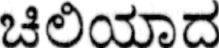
ಚಿಲಿಯಾದ
